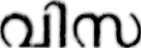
വിസ
